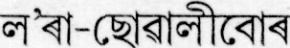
ল'ৰা-ছোৱালীবোৰ
